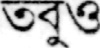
তবুও
